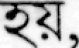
হয়,
